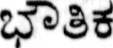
ಭೌತಿಕ
